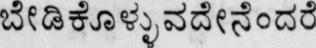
ಬೇಡಿಕೊಳ್ಳುವದೇನೆಂದರೆ
